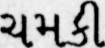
ચમકી
